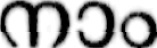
നാം
